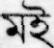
মই
